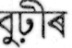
বুঢ়ীৰ
